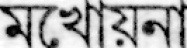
মখোয়না
